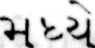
મધ્યે
